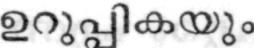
ഉറുപ്പികയും
